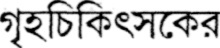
গৃহচিকিত্সকের
